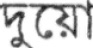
দুয়ো
